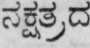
ನಕ್ಷತ್ರದ
